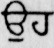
ਉਹ
